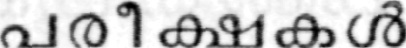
പരീക്ഷകള്‍
